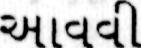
આવવી
